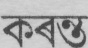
কৰন্ত
